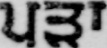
ਪੜਾ
